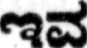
ಇವ
